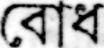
বোধ
